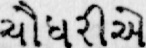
ચૌધરીએ
